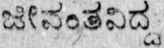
ಜೀವಂತವಿದ್ದ
